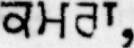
ਕਮਰਾ,
